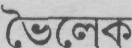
ভৈলেক
